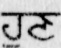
ਹੁਣ
